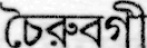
চৈরুবগী
